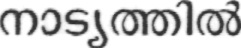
നാട്യത്തില്‍
